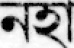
নহা
